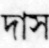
দাস
